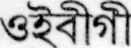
ওইবীগী
